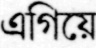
এগিয়ে
